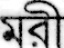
মরী
